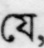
যে,
